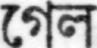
গেল
